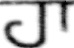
ਹਾਂ
